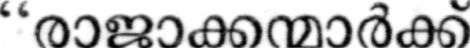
"രാജാക്കന്മാര്‍ക്ക്
